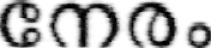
നേരം
